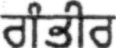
ਗੰਭੀਰ
